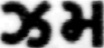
ઝમ
